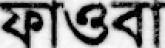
ফাওবা
